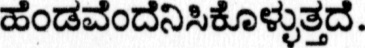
ಹೆಂಡವೆಂದೆನಿಸಿಕೊಳ್ಳುತ್ತದೆ.
